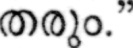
തരും.”
